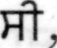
ਸੀ,
